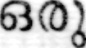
ഒരു
